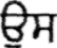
ਉਸ
